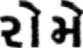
રોમે
